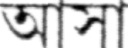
আসা
